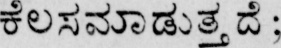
ಕೆಲಸಮಾಡುತ್ತದೆ;
